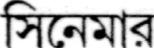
সিনেমার
